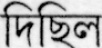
দিছিল
